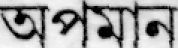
অপমান
